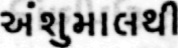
અંશુમાલથી
